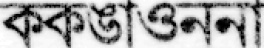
ককঙাওননা
